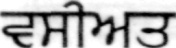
ਵਸੀਅਤ
